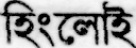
হিংলোই
